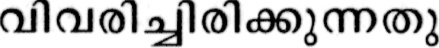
വിവരിച്ചിരിക്കുന്നതു
